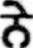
ਨੇ
